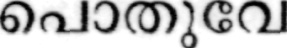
പൊതുവേ
